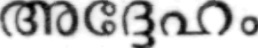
അദ്ദേഹം
